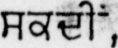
ਸਕਦੀ,
